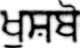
ਖੁਸ਼ਬੋ
